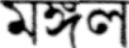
মঙ্গল
